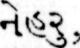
નેહરુ,
